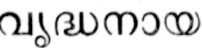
വൃദ്ധനായ
